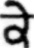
ਕੇ
